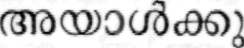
അയാള്‍ക്കു
